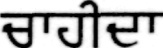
ਚਾਹੀਦਾ
